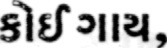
કોઈગાય,
